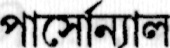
পার্সোন্যাল
